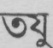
তযু
